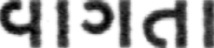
વાગતા
